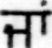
ਜਾਂ
